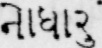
નોધારું
